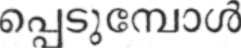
പ്പെടുമ്പോള്‍
